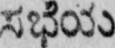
ಸಭೆಯ
